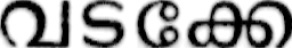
വടക്കേ
